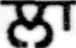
ਲਾ
